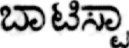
ಬಾಟಿಸ್ಟಾ
